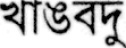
খাঙবদু
